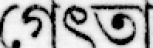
গেৎতা
